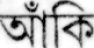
আঁকি
